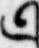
এ
